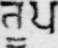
ਰੂਪ
